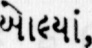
બોલ્યાં,
